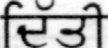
ਦਿੱਤੀ
